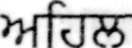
ਅਹਿਲ
